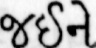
જઈને
